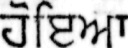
ਹੋਇਆ
